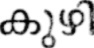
കുഴി
